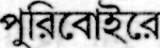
পুরিবোইরে
